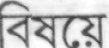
বিষয়ে
